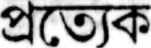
প্রত্যেক
